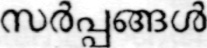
സര്‍പ്പങ്ങള്‍
